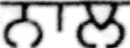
ਨਾਲ
